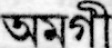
অমগী
